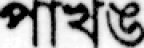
পাখঙ
